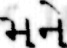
મને
